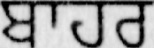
ਬਾਹਰ
